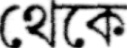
থেকে
